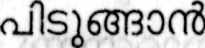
പിടുങ്ങാന്‍
